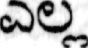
ಎಲ್ಲ
